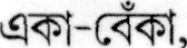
একা-বেঁকা,
